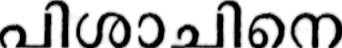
പിശാചിനെ
